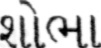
શોભા
